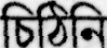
চিঠিনি
